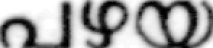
പഴയ
